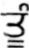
ਤੂੰ
